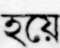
হয়ে
